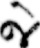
જે
